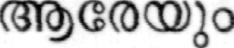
ആരേയും
